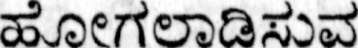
ಹೋಗಲಾಡಿಸುವ
